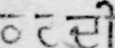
ਕਰਦੀ
